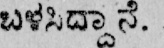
ಬಳಸಿದ್ದಾನೆ.
